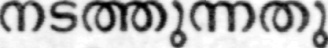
നടത്തുന്നതു
